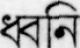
ধ্বনি
